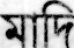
মাদি
